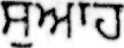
ਸੁਆਹ
